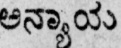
ಅನ್ಯಾಯ
